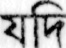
যদি
